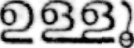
ഉള്ളൂ
